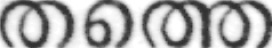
തത്തെ
